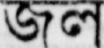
জল
